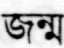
জন্ম
